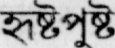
হৃষ্টপুষ্ট
